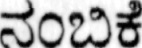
ನಂಬಿಕೆ
